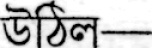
উঠিল-
